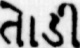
તોડી
